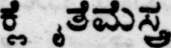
ಕ್ಲೈತೆಮೆಸ್ತ್ರ
